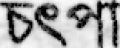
চৎপা
